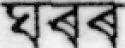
ঘৰৰ
